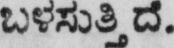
ಬಳಸುತ್ತಿದೆ.
